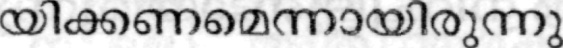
യിക്കണമെന്നായിരുന്നു
